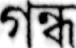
গন্ধ
